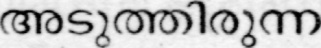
അടുത്തിരുന്ന
